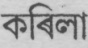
কৰিলা
